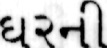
ઘરની
